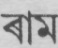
ৰাম
